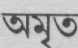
অমৃত
